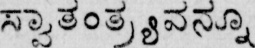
ಸ್ವಾತಂತ್ರ್ಯವನ್ನೂ
